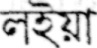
লইয়া
